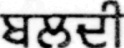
ਬਲਦੀ
